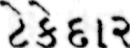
ટેકેદાર
